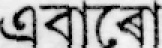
এবাৰো
